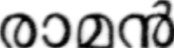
രാമന്‍
